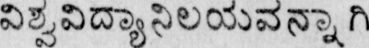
ವಿಶ್ವವಿದ್ಯಾನಿಲಯವನ್ನಾಗಿ
